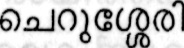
ചെറുശ്ശേരി
